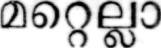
മറ്റെല്ലാ
